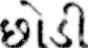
છોડી
